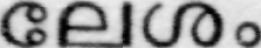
ലേശം
